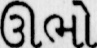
ઊભો
